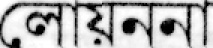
লোয়ননা
